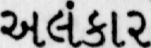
અલંકાર
